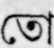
তো
